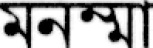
মনম্মা
